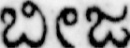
ಬೀಜ
